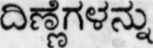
ದಿಣ್ಣೆಗಳನ್ನು
